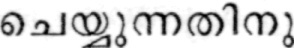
ചെയ്യുന്നതിനു
